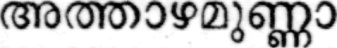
അത്താഴമുണ്ണാ
